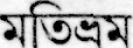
মতিভ্রম
